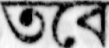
তবে
